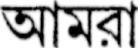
আমরা
